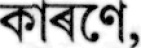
কাৰণে,
